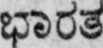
ಭಾರತ
